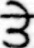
ਤੇ
